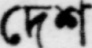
দেশ
